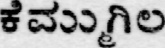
ಕೆಮ್ಮುಗಿಲ
